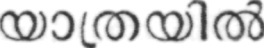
യാത്രയില്‍
